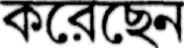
করেছেন
